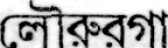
লৌরুরগা
